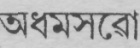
অধমসৱো
